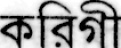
করিগী
